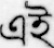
এই
